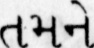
તમને
